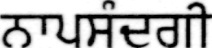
ਨਾਪਸੰਦਗੀ
